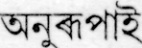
অনুৰূপাই
